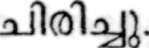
ചിരിച്ചു.
